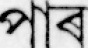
পাৰ
